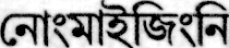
নোংমাইজিংনি
